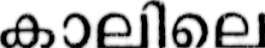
കാലിലെ
